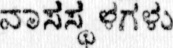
ವಾಸಸ್ಥಳಗಳು
